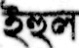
ইহুল
